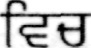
ਵਿਚ
